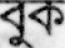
বুক
